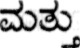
ಮತ್ತು
